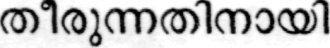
തീരുന്നതിനായി
